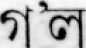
গ'ল
